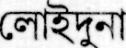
লোইদুনা
